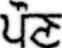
ਪੌਣ
